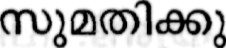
സുമതിക്കു
